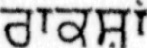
ਰਾਕਸ਼ਾਂ
